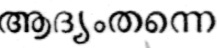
ആദ്യംതന്നെ
